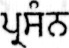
ਪ੍ਰਸੰਨ
